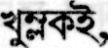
খুম্লকই,
